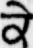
ਕੇ
